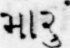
મારું
